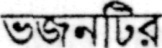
ভজনটির
